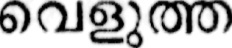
വെളുത്ത
